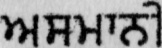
ਅਸਮਾਨੀ
